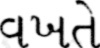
વખતે
